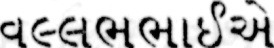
વલ્લભભાઈએ
